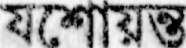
যশোয়ন্ত
